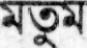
মতুম
